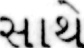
સાથે
